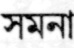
সমনা
